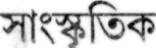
সাংস্কৃতিক
